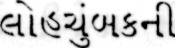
લોહચુંબકની
